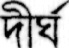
দীর্ঘ
